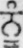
ਨੂੰ
